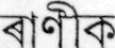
ৰাণীক
